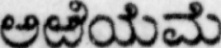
ಅಱಯೆಮೆ
